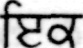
ਇਕ
